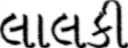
લાલકી
